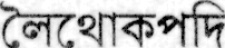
লৈথোকপদি
